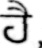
ਹੈ,
